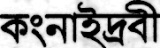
কংনাইদ্রবী
